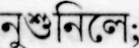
নুশুনিলে;
